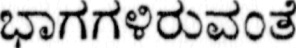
ಭಾಗಗಳಿರುವಂತೆ
